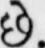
છે.
